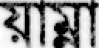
য়াম্না
